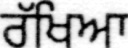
ਰੱਖਿਆ
